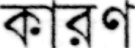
কারণ
